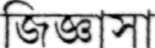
জিজ্ঞাসা
